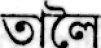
তালৈ
